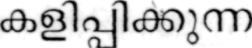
കളിപ്പിക്കുന്ന
